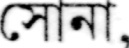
সোনা,
